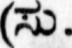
(ಸು.
